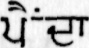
ਪੈਂਦਾ
